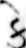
કે
